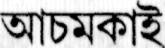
আচমকাই
